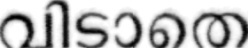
വിടാതെ
